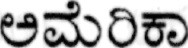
ಅಮೆರಿಕಾ
